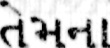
તેમના
